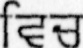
ਵਿਚ
